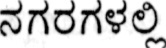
ನಗರಗಳಲ್ಲಿ
